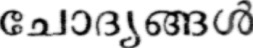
ചോദ്യങ്ങള്‍
